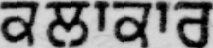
ਕਲਾਕਾਰ
